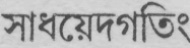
সাধয়েদগতিং
